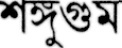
শঙ্গুগুম
